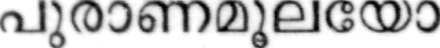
പുരാണമൂലയോ
